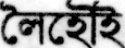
লৈহৌই
